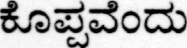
ಕೊಪ್ಪವೆಂದು
